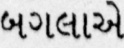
બગલાએ
